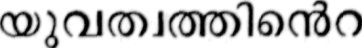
യുവത്വത്തിന്റെ
